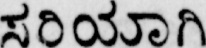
ಸರಿಯಾಗಿ
